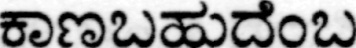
ಕಾಣಬಹುದೆಂಬ
